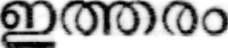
ഇത്തരം
